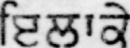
ਇਲਾਕੇ
